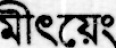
মীৎয়েং
